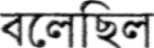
বলেছিল
